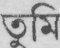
তুমি
